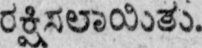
ರಕ್ಷಿಸಲಾಯಿತು.
